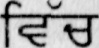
ਵਿੱਚ
